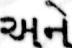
અને
